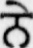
ਨੇ
